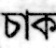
চাক
